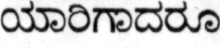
ಯಾರಿಗಾದರೂ
